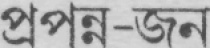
প্ৰপন্ন-জন
